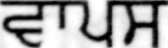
ਵਾਪਸ
